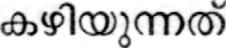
കഴിയുന്നത്
